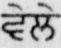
ਵੇਲੇ
